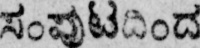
ಸಂಪುಟದಿಂದ
